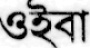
ওইবা
